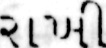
રાખી
